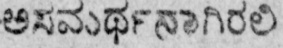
ಅಸಮರ್ಥನಾಗಿರಲಿ
